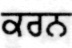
ਕਰਨ
